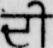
ਦੀ
